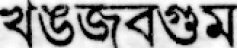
খঙজবগুম
